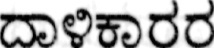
ದಾಳಿಕಾರರ
